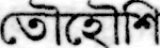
তৌহৌশি
